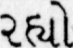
રહ્યો
